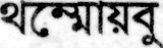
থম্মোয়বু
